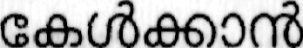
കേള്‍ക്കാന്‍
